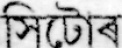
সিটোৰ
